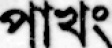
পাখং
